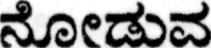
ನೋಡುವ
